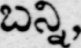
ಬನ್ನಿ,
